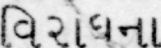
વિરોધના
